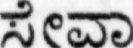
ಸೇವಾ
